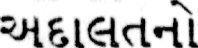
અદાલતનો
